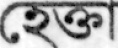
হেক্তা
